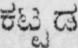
ಕಟ್ಟಡ
